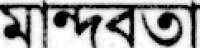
মান্দবতা
